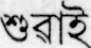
শুৱাই
